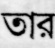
তার
